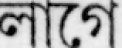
লাগে
